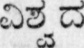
ವಿಶ್ವದ
